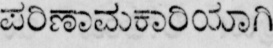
ಪರಿಣಾಮಕಾರಿಯಾಗಿ
